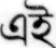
এই
